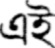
এই
